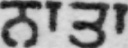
ਨਾਤਾ
